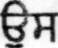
ਉਸ
